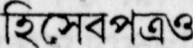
হিসেবপত্রও
